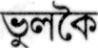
ভুলকৈ
